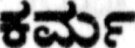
ಕರ್ಮ
